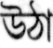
উঠা
